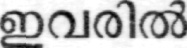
ഇവരില്‍
